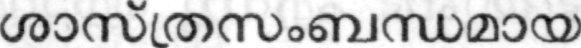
ശാസ്ത്രസംബന്ധമായ
